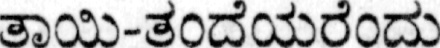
ತಾಯಿ-ತಂದೆಯರೆಂದು
